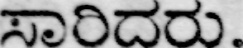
ಸಾರಿದರು.
